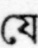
যে
